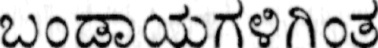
ಬಂಡಾಯಗಳಿಗಿಂತ
